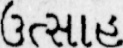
ઉત્સાહ
